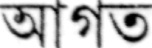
আগত
